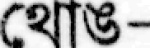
থোঙ-
